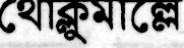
থোক্লুমাল্লে
